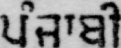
ਪੰਜਾਬੀ
